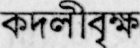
কদলীবৃক্ষ
